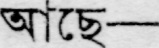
আছে—
